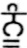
ਨੂੰ
